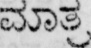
ಮಾತ್ರ
